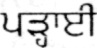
ਪੜ੍ਹਾਈ
